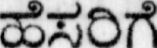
ಹೆಸರಿಗೆ
